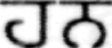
ਹਨ
